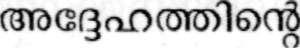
അദ്ദേഹത്തിന്റെ
